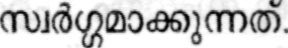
സ്വര്‍ഗ്ഗമാക്കുന്നത്.
